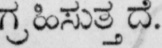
ಗ್ರಹಿಸುತ್ತದೆ.
